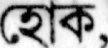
হোক,
